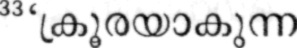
33'ക്രൂരയാകുന്ന
